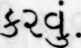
કરવું.
